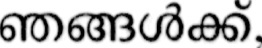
ഞങ്ങള്‍ക്ക്,
